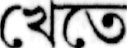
খেতে
